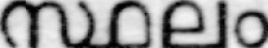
സ്ഥലം
